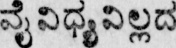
ವೈವಿಧ್ಯವಿಲ್ಲದ
